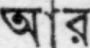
আর
